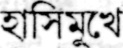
হাসিমুখে
